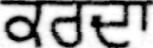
ਕਰਦਾ
